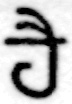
ਹੈ
